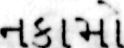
નકામો
